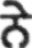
ਨੇ
